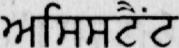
ਅਸਿਸਟੈਂਟ
